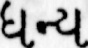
ધન્ય
